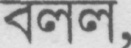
বলল,
